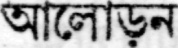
আলোড়ন
